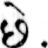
છે.
